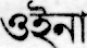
ওইনা
